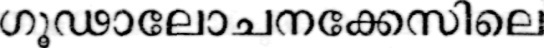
ഗൂഢാലോചനക്കേസിലെ
